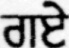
ਗਏ
